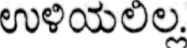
ಉಳಿಯಲಿಲ್ಲ.
